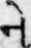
ને
